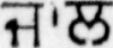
ਜਾਲ
